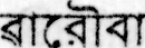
ৱারৌবা
